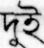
দুই
